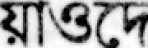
য়াওদে
